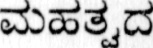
ಮಹತ್ವದ
